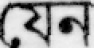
যেন
